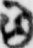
છે
